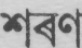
শৰণ
